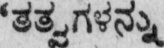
‘ತತ್ವಗಳನ್ನು
